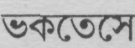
ভকতেসে
